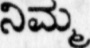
ನಿಮ್ಮ
